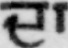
ਦਾ
